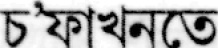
চ'ফাখনতে
